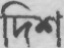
দিশ
